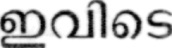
ഇവിടെ
